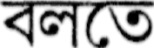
বলতে
